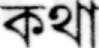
কথা
